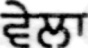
ਵੇਲਾ
